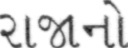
રાજાનો
